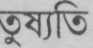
তুষ্যতি
